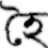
হৈ
